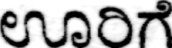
ಊರಿಗೆ
